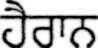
ਹੈਰਾਨ
